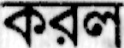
করল
